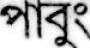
পাবুং
